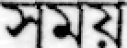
সময়
